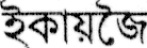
ইকায়জৈ
